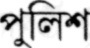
পুলিশ
